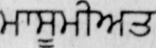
ਮਾਸੂਮੀਅਤ
